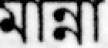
মান
